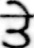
ਤੇ
